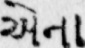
એના
